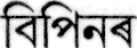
বিপিনৰ
